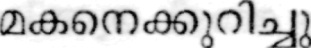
മകനെക്കുറിച്ചു
